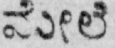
ಮೇಲೆ
